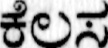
ಕೆಲಸ
